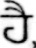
ਹੈ,
